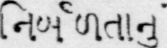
નિર્બળતાનું
